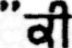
''ਕੀ
